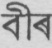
বীৰ
